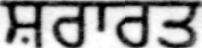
ਸ਼ਰਾਰਤ
